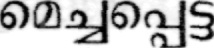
മെച്ചപ്പെട്ട
